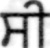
ਸੀ
